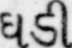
ઘડી
